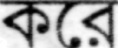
করে
